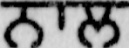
ਨਾਲ
